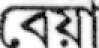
বেয়া
